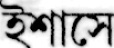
ইশাসে
